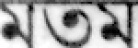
মতম
